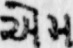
એમ
